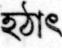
হঠাত্
